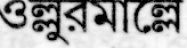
ওল্লুরমাল্লে
